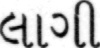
લાગી
